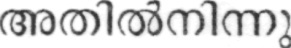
അതില്‍നിന്നു
